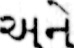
અને
